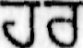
ਹਰ
